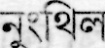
নুংথিল
